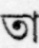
তা
